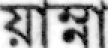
য়াম্না
